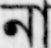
না
